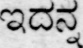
ಇದನ್ನ
